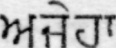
ਅਜੇਹਾ
